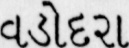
વડોદરા
